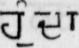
ਹੁੰਦਾ
